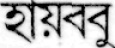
হায়ববু
